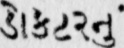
ડોક્ટરનું
